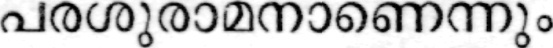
പരശുരാമനാണെന്നും
